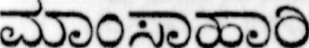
ಮಾಂಸಾಹಾರಿ
